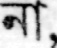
না,
